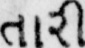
તારી
